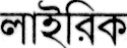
লাইরিক
